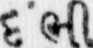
દંભી
